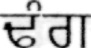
ਢੰਗ
